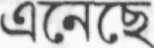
এনেছে
